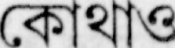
কোথাও
